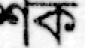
শক
